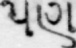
પણ
